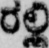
ರಲ್ಲಿ
